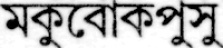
মকুবোকপুসু
